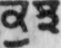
ਕੁਝ
